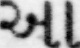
આ
